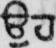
ਉਹ
